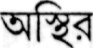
অস্থির
